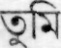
তুমি
